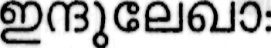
ഇന്ദുലേഖാ:
